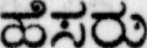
ಹೆಸರು
